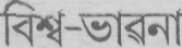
বিশ্ব-ভাৱনা
